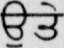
ਉਤੇ
